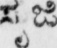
ಸೃಜಿ
